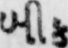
બીક
